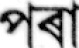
পৰা
